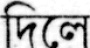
দিলে
